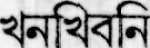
খনখিবনি
